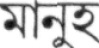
মানুহ
